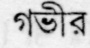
গভীর
